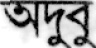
অদুবু
